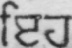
ਇਹ
